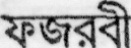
ফজরবী
